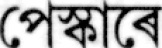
পেস্কাৰে
